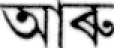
আৰু
